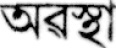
অৱস্থা
